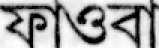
ফাওবা
